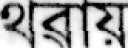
থৱায়
